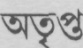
অতৃপ্ত
